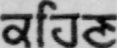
ਕਹਿਣ
